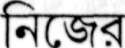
নিজের
